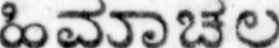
ಹಿಮಾಚಲ
